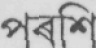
পৰশি
